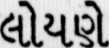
લોયણે
